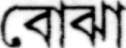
বোঝা
